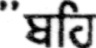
''ਬਹਿ
